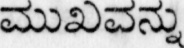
ಮುಖವನ್ನು
